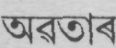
অৱতাৰ
